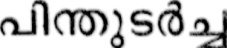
പിന്തുടര്‍ച്ച
